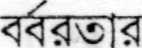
বর্বরতার
